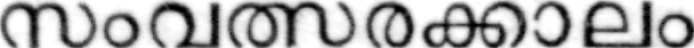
സംവത്സരക്കാലം
